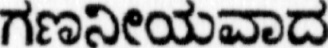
ಗಣನೀಯವಾದ
